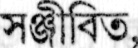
সঞ্জীবিত,
